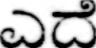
ಎದೆ
